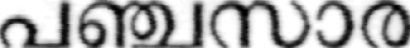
പഞ്ചസാര
